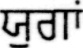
ਯੁਗਾਂ
